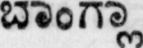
ಬಾಂಗ್ಲಾ
